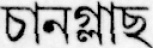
চানগ্লাছ
